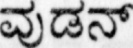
ವುಡನ್
